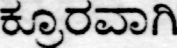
ಕ್ರೂರವಾಗಿ
